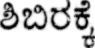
ಶಿಬಿರಕ್ಕೆ
